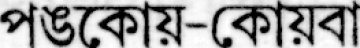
পঙকোয়-কোয়বা
